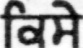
ਕਿਸੇ
